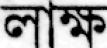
লাক্ষ
